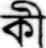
কী
